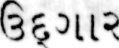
ઉદ્ગાર
